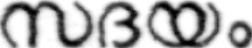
സദയം
